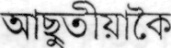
আছুতীয়াকৈ
